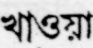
খাওয়া
